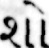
શો
